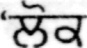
'ਲੋਕ
